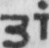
ਤਾਂ
